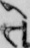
તે
